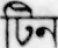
টিন
